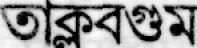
তাক্লবগুম
